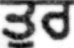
ਤੁਰ
